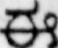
ಈ
